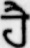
ਹੈ
